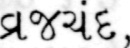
વ્રજચંદ,
